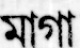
মাগা
